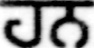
ਹਨ
